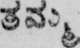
ತಮ್ಮ
